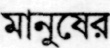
মানুষের
